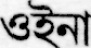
ওইনা
